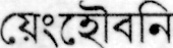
য়েংহৌবনি
